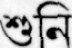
শুনি
